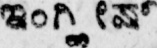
ಇಂಗ್ಲೀಷ್
